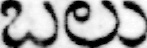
ಬಲು
